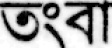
তংবা
